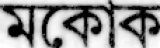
মকোক
